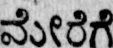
ಮೇರೆಗೆ
